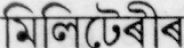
মিলিটেৰীৰ
